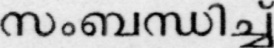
സംബന്ധിച്ച്
